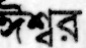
ঈশ্বর
